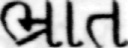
ભ્રાત
